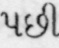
પછી
